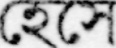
হেসে
